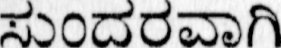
ಸುಂದರವಾಗಿ
